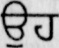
ਉਹ
